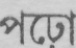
পঢ়ো
